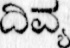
ದಿವ್ಯ
